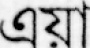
এয়া
